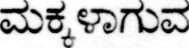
ಮಕ್ಕಳಾಗುವ
